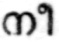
നീ
